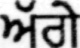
ਅੱਗੇ
